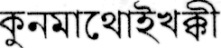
কুনমাথোইখক্কী
